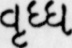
વૃધ્ધ
